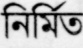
নির্মিত
